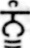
ਨੂੰ
